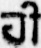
ਹੀ
